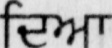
ਦਿਆ
